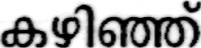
കഴിഞ്ഞ്
